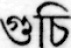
গুচি
